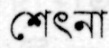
শেৎনা
